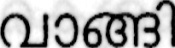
വാങ്ങി
